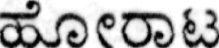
ಹೋರಾಟ
